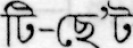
টি-ছে'ট
